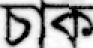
চাক
